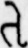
તે
